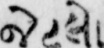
જેટલો
